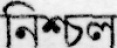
নিশ্চল
